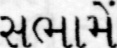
સભામેં
